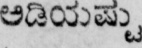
ಅಡಿಯಷ್ಟು
